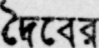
দৈবের
